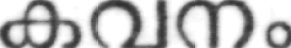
കവനം
